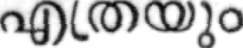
എത്രയും
